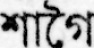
শাগৈ
